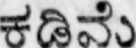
ಕಡಿಮೆ
